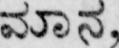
ಮಾನ,
